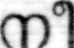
നീ
